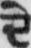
ਦੇ
